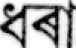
ধৰা
